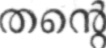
തന്റെ
